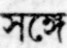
সঙ্গে
